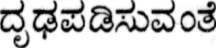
ದೃಢಪಡಿಸುವಂತೆ
